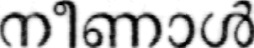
നീണാള്‍
